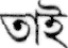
তাই
